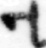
ન
